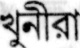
খুনীরা
